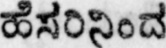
ಹೆಸರಿನಿಂದ
